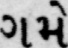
ગમે
